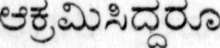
ಆಕ್ರಮಿಸಿದ್ದರೂ
